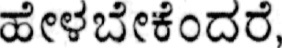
ಹೇಳಬೇಕೆಂದರೆ,
